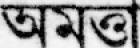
অমত্তা
